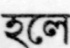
হলে
